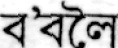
ব'বলৈ
